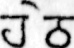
ਹੇਠ
